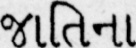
જાતિના
